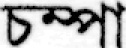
চম্পা
